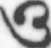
ও
